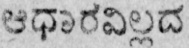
ಆಧಾರವಿಲ್ಲದ
